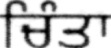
ਚਿੰਤਾ
